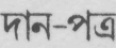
দান-পত্ৰ
